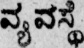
ವ್ಯವಸ್ಥೆ
